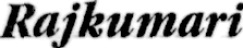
Rajkumari
